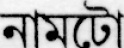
নামটো
